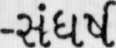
-સંઘર્ષ
